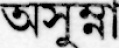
অসুম্না
